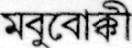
মবুবোক্কী
